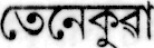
তেনেকুৱা
